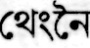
থেংনৈ
